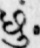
છું
